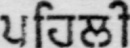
ਪਹਿਲੀ
